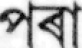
পৰা
